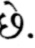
છે.
